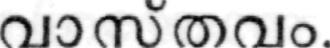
വാസ്തവം.
